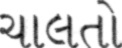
ચાલતો
